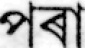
পৰা
